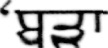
'ਬੜਾ
